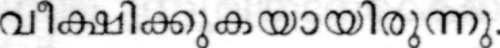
വീക്ഷിക്കുകയായിരുന്നു.
